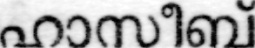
ഹാസീബ്
